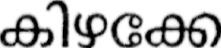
കിഴക്കേ
